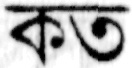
কত
